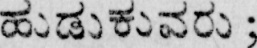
ಹುಡುಕುವರು;
